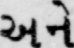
અને
